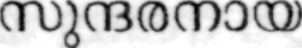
സുന്ദരനായ
